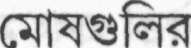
মোষগুলির
